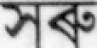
সৰু
